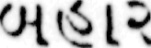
બહાર
